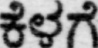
ಕೆಳಗೆ
